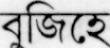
বুজিহে
